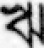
ঋ
